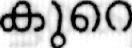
കുറെ
